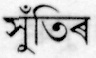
সুঁতিৰ
